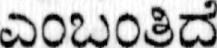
ಎಂಬಂತಿದೆ
